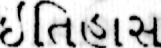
ઇતિહાસ
